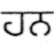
ਹਨ
